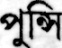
পুন্সি
